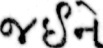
જઈને
